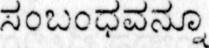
ಸಂಬಂಧವನ್ನೂ
